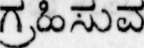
ಗ್ರಹಿಸುವ
